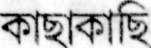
কাছাকাছি
